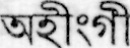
অহীংগী
